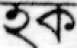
হক
